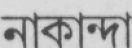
নাকান্দা
